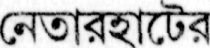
নেতারহাটের
